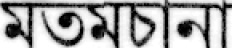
মতমচানা
